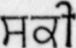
ਸਕੀ
